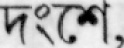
দংশে,
